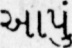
આપું
